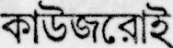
কাউজরোই
